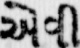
એવી
